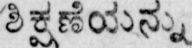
ಶಿಕ್ಷಣೆಯನ್ನು
